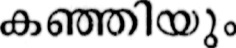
കഞ്ഞിയും
